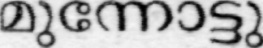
മുന്നോട്ടു
